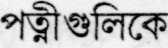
পত্নীগুলিকে
